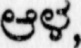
ಆಳ,
